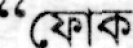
“ফোক
